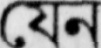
যেন
